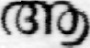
ആ
